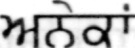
ਅਨੇਕਾਂ
